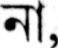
না,
